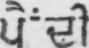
ਪੈਂਦੀ
